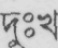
দুঃখ
